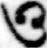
ও
